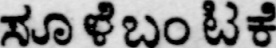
ಸೂಳೆಬಂಟಿಕೆ
